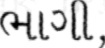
ભાગી,
